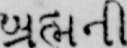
બ્રહ્મની
